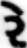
રે
